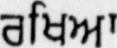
ਰਖਿਆ
